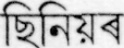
ছিনিয়ৰ
